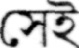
সেই
